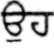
ਉਹ
